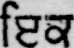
ਇਕ
